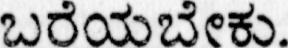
ಬರೆಯಬೇಕು.
